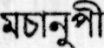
মচানুপী
